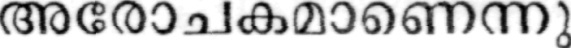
അരോചകമാണെന്നു
